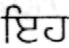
ਇਹ
